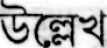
উল্লেখ
